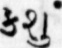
કશું
